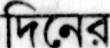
দিনের
